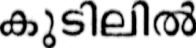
കുടിലില്‍
